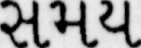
સમય
